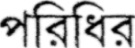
পরিধির
